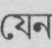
যেন
